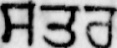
ਸਤਰ
